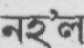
নহ'ল
